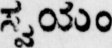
ಸ್ವಯಂ
